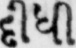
દીધી
